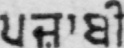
ਪਜ਼ਾਬੀ
